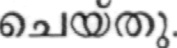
ചെയ്തു.
